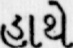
હાથે
